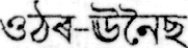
ওঠৰ-ঊনৈছ
